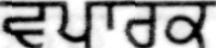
ਵਪਾਰਕ
